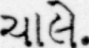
ચાલે.
